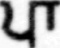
ਪਾ
